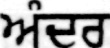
ਅੰਦਰ
